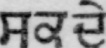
ਸਕਦੇ
